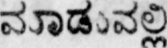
ಮಾಡುವಲ್ಲಿ
